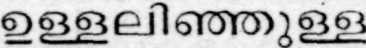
ഉള്ളലിഞ്ഞുള്ള
